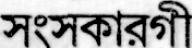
সংসকারগী
